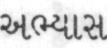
અભ્યાસ
